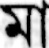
মা
